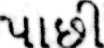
પાછી
